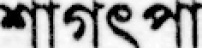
শাগৎপা
